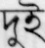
দুই
